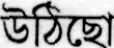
উঠিছো
